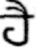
ਹੈ
